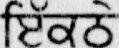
ਇੱਕਠੇ
